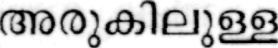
അരുകിലുള്ള
